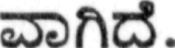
ವಾಗಿದೆ.
